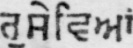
ਰੁਸੇਵਿਆਂ
